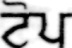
ਟੋਪ
